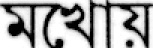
মখোয়
